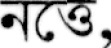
নত্তে,
